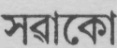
সৱাকো
